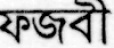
ফজবী
